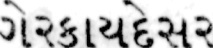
ગેરકાયદેસર
